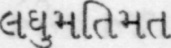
લઘુમતિમત
